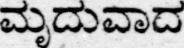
ಮೃದುವಾದ
